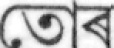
তোৰ
